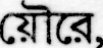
য়ৌরে,
